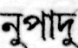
নুপাদু
